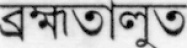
ব্রহ্মতালুত
